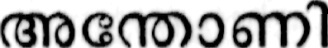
അന്തോണി
